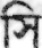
সি
